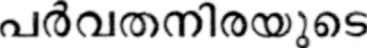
പര്‍വതനിരയുടെ
